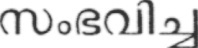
സംഭവിച്ച
